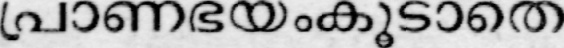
പ്രാണഭയംകൂടാതെ
